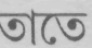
তাতে
